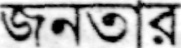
জনতার
